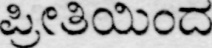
ಪ್ರೀತಿಯಿಂದ
